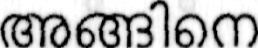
അങ്ങിനെ
